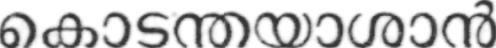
കൊടന്തയാശാന്‍
